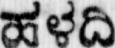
ಹಳದಿ
